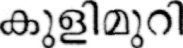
കുളിമുറി
